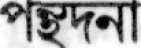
পন্থদনা
